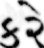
કરે
